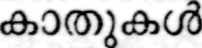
കാതുകള്‍
